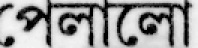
পেলালো
